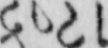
દ્રષ્ટા
